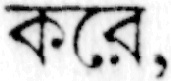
করে,
